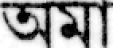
অমা
